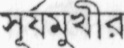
সূর্যমুখীর
